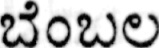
ಬೆಂಬಲ
